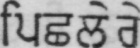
ਪਿਛਲੇਰੇ
